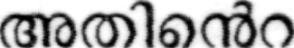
അതിന്റെ
